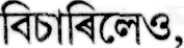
বিচাৰিলেও,
